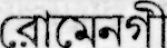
রোমেনগী
